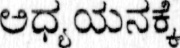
ಅಧ್ಯಯನಕ್ಕೆ
